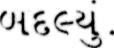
બદલ્યું.
